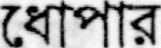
ধোপার
